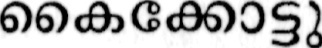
കൈക്കോട്ടു
